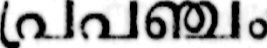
പ്രപഞ്ചം
